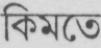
কিমতে
